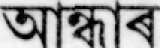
আন্ধাৰ
